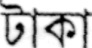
টাকা
